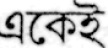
একেই
